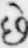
છે
